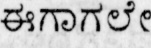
ಈಗಾಗಲೇ
